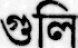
গুলি
